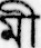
মী
